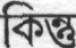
কিন্তু
